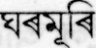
ঘৰমূৰি
